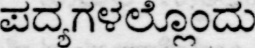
ಪದ್ಯಗಳಲ್ಲೊಂದು
